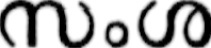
സംശ
